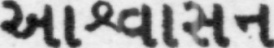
આશ્વાસન
